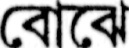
বোঝে
